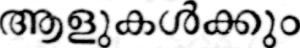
ആളുകള്‍ക്കും
